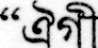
“ঐগী
